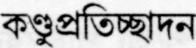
কণ্ডুপ্রতিচ্ছাদন
